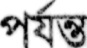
পর্যন্ত
